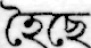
হৈছে
